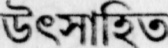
উৎসাহিত
